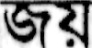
জয়
